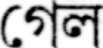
গেল
